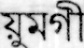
য়ুমগী
